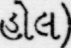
હોલ)
